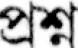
প্রশ্ন
